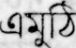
এমুঠি
